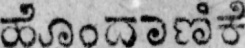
ಹೊಂದಾಣಿಕೆ
